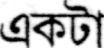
একটা
